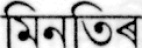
মিনতিৰ
